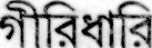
গীরিধারি
